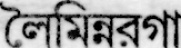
লৈমিন্নরগা
